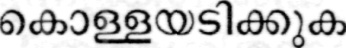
കൊള്ളയടിക്കുക
